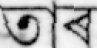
তাৰ
